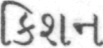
કિશન
